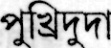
পুখ্রিদুদা
